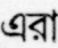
এরা
